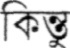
কিন্তু
